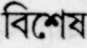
বিশেষ
